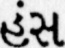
હંસ
